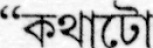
"কথাটো
